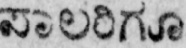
ಪಾಲರಿಗೂ
